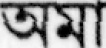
অমা
